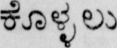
ಕೊಳ್ಳಲು
